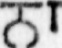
ਨਾ
